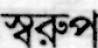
স্বরুপ
